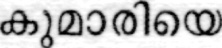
കുമാരിയെ
